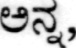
ಅನ್ನ,
